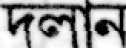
দলান
